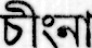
চীংনা
